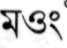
মওং
